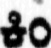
ಕಿಂ
